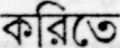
করিতে
